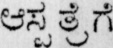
ಆಸ್ಪತ್ರೆಗೆ
